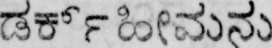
ಡರ್ಕ್‌ಹೀಮನು
